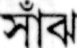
সাঁঝ
